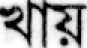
খায়
